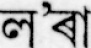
ল'ৰা
